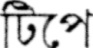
টিপে
